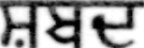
ਸ਼ਬਦ
